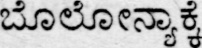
ಬೊಲೋನ್ಯಾಕ್ಕೆ
